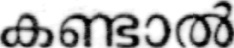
കണ്ടാല്‍
